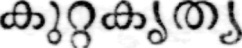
കുറ്റകൃത്യ
